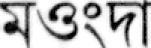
মওংদা
